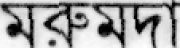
মরুমদা
